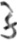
કે
